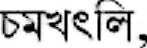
চমখৎলি,
